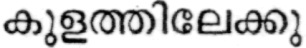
കുളത്തിലേക്കു
